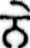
ਨੇ
